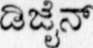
ಡಿಜೈನ್
